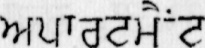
ਅਪਾਰਟਮੈਂਟ
